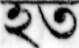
হত
